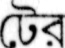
টের
